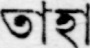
তাহা
